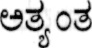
ಅತ್ಯಂತ
